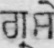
ਗ੍ਰਸੇ
